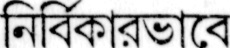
নির্বিকারভাবে
